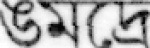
ঙমদ্রে
